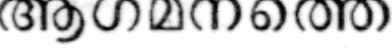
ആഗമനത്തെ
